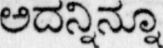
ಅದನ್ನಿನ್ನೂ
